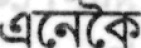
এনেকৈ
